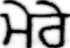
ਮੇਰੇ
